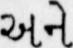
અને
